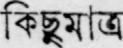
কিছুমাত্র
